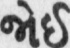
જોઈ
